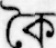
কৈ
